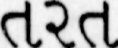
તરત
